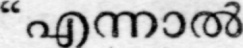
"എന്നാല്‍
